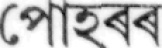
পোহৰৰ
